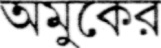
অমুকের
